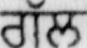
ਗੱਲ
